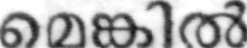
മെങ്കില്‍
